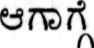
ಆಗಾಗ್ಗೆ
